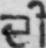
ਦੀ
